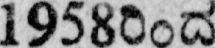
1958ರಿಂದ
